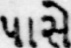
પાસે
